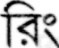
রিং
